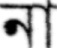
না
